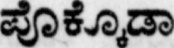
ಪೊಕ್ಕೊಡಾ
